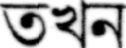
তখন
